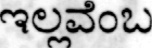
ಇಲ್ಲವೆಂಬ
